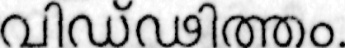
വിഡ്ഢിത്തം.
